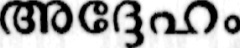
അദ്ദേഹം
